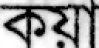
কয়া
